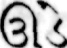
ઊંડે
